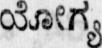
ಯೋಗ್ಯ
